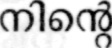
നിന്റെ
